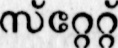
സ്റ്റേറ്റ്
